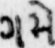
ગમે
